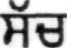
ਸੱਚ
